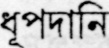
ধূপদানি
